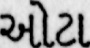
ઓટા
